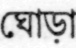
ঘোড়া
